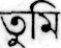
তুমি
